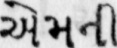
એમની
